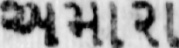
અમારા
